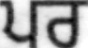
ਪਰ
